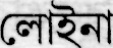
লোইনা
